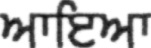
ਆਇਆ
